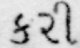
કરી
